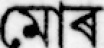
মোৰ
